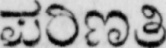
ಪರಿಣತಿ
